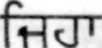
ਜਿਹਾ
